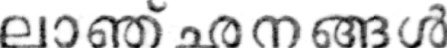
ലാഞ്ഛനങ്ങള്‍
